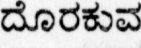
ದೊರಕುವ
